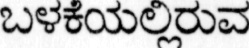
ಬಳಕೆಯಲ್ಲಿರುವ
